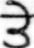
ਤੇ
